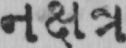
નક્ષત્ર
